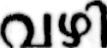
വഴി
